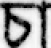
চা
